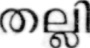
തല്ലി
